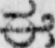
ಈ
